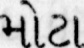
મોટા
